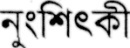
নুংশিৎকী
